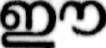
ഈ
